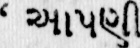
'આપણી
